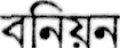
বনিয়ন
